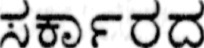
ಸರ್ಕಾರದ
